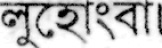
লুহোংবা
